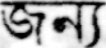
জন্য
